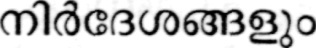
നിര്‍ദേശങ്ങളും
